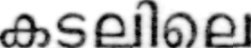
കടലിലെ
